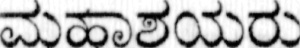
ಮಹಾಶಯರು
